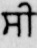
ਸੀ
